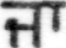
ਜਾ
